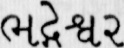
ભદ્રેશ્વર
